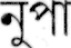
নুপা
